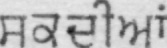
ਸਕਦੀਆਂ
